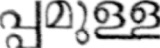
പ്പമുള്ള
